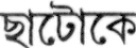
ছাটোকে
